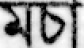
মচা
